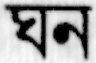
ঘন
